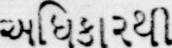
અધિકારથી
